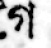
গৈ
